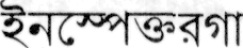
ইনস্পেক্তরগা
